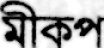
মীকপ
